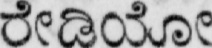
ರೇಡಿಯೋ
